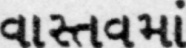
વાસ્તવમાં
